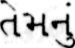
તેમનું
